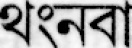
থংনবা
